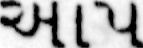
આપ
